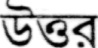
উত্তর
